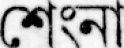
শেংনা
